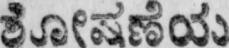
ಶೋಷಣೆಯ
